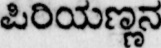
ಪಿರಿಯಣ್ಣನ
